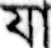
যা
